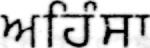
ਅਹਿੰਸਾ
